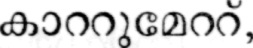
കാററുമേററ്,
